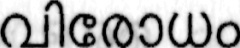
വിരോധം
